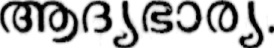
ആദ്യഭാര്യ.
